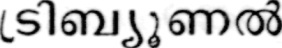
ട്രിബ്യൂണല്‍
